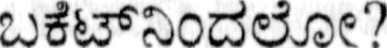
ಬಕೆಟ್‌ನಿಂದಲೋ?
